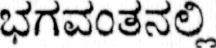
ಭಗವಂತನಲ್ಲಿ
